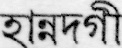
হান্নদগী
